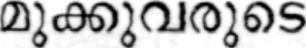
മുക്കുവരുടെ
